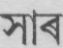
সাৰ
